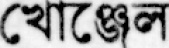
খোঞ্জেল
